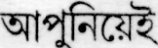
আপুনিয়েই
